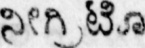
ನೀಗ್ರಿಟೊ
